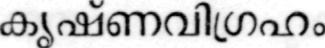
കൃഷ്ണവിഗ്രഹം
